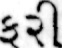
ફરી
